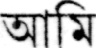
আমি
